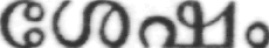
ശേഷം
